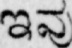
ಇವು
